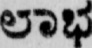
ಲಾಭ
